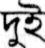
দুই
